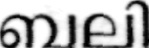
ബലി
